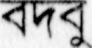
বদবু
